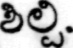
ಶಿಲ್ಪಿ.
